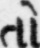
તો
